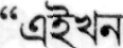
"এইখন
